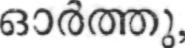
ഓര്‍ത്തു.
